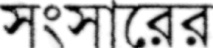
সংসারের
